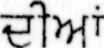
ਦੀਆਂ
